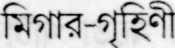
মিগার-গৃহিণী
